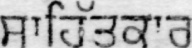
ਸਾਹਿੱਤਕਾਰ
